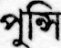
পুন্সি
